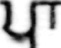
ਪਾ
